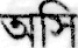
অসি
